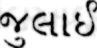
જુલાઈ
